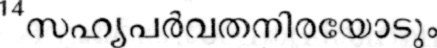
14സഹ്യപര്‍വതനിരയോടും
